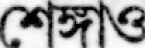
শেঙ্গাও
